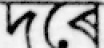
দৰে
